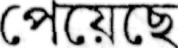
পেয়েছে
